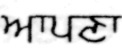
ਆਪਣਾ
